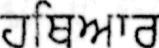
ਹਥਿਆਰ
